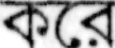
করে
